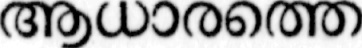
ആധാരത്തെ
